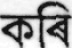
কৰি
